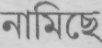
নামিছে
